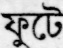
ফুটে
